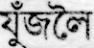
যুঁজলৈ
